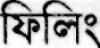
ফিলিং
